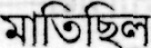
মাতিছিল
